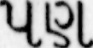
પણ
